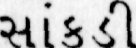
સાંકડી
